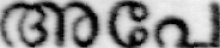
അപേ
